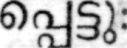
പ്പെട്ടു:
